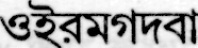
ওইরমগদবা
